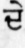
ਦੇ
